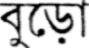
বুড়ো
